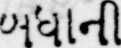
બધાની
